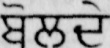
ਬੋਲਦੇ
